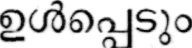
ഉള്‍പ്പെടും
